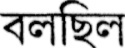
বলছিল
